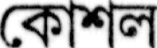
কোশল
